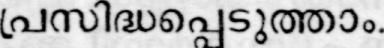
പ്രസിദ്ധപ്പെടുത്താം.
